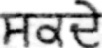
ਸਕਦੇ
